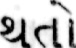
થતો
